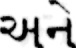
અને
